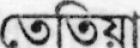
তেতিয়া
